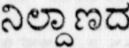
ನಿಲ್ದಾಣದ
